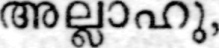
അല്ലാഹു,
